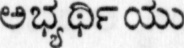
ಅಭ್ಯರ್ಥಿಯು
